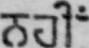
ਨਹੀਂ
